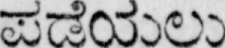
ಪಡೆಯಲು
